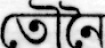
তৌনৈ
